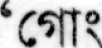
‘গোং
